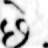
છે.
